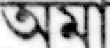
অমা
